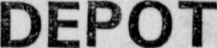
DEPOT
